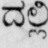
ದಲ್ಲಿ
